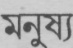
মনুষ্য
